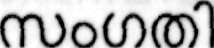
സംഗതി
